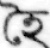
হৈ
